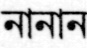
নানান
